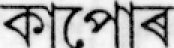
কাপোৰ
